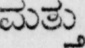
ಮತ್ತು
